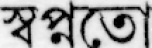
স্বপ্নতো
